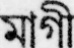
মাগী
